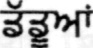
ਡੱਡੂਆਂ
